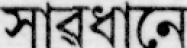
সাৱধানে
